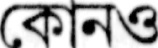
কোনও
